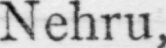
Nehru,
